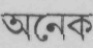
অনেক
